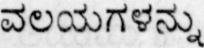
ವಲಯಗಳನ್ನು
